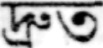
দ্রুত
